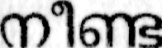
നീണ്ട
